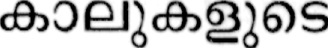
കാലുകളുടെ
